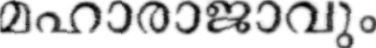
മഹാരാജാവും
